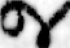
જ
